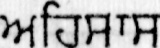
ਅਹਿਸਾਸ
